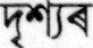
দৃশ্যৰ
